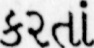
કરતાં
